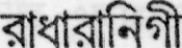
রাধারানিগী
